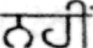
ਨਹੀਂ
